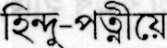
হিন্দু-পত্নীয়ে
